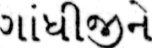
ગાંધીજીને
